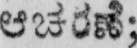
ಆಚರಣೆ;
